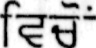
ਵਿਚੋਂ
